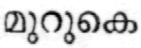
മുറുകെ
